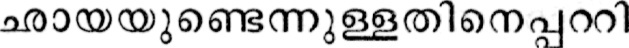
ഛായയുണ്ടെന്നുള്ളതിനെപ്പററി
